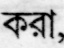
করা,
